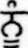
ਨੂੰ
